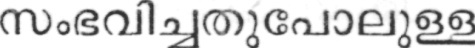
സംഭവിച്ചതുപോലുള്ള
